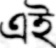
এই
